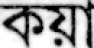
কয়া
